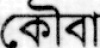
কৌবা
